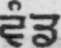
ਵੰਡ
